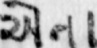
એના
